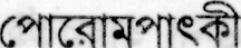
পোরোমপাৎকী
